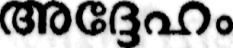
അദ്ദേഹം
